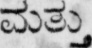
ಮತ್ತು
